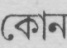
কোন
